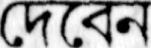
দেবেন
